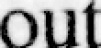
out
